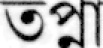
তপ্না
